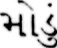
મોડું
